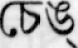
চেঙ্
